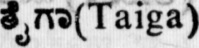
ತೈಗಾ(Taiga)
